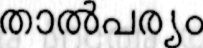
താല്‍പര്യം
